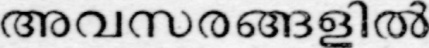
അവസരങ്ങളില്‍
